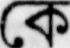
কে
